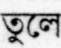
তুলে
